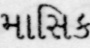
માસિક
